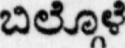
ಬಿಲ್ಗೊಳೆ
